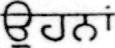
ਉਹਨਾਂ
